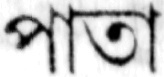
পাতা
